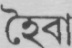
হৈবা
